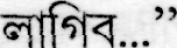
লাগিব..."
